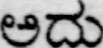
ಅದು
